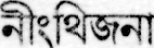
নীংথিজনা
